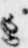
હું
